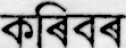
কৰিবৰ
